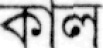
কাল
